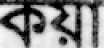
কয়া
